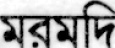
মরমদি
